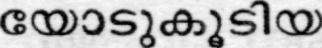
യോടുകൂടിയ
